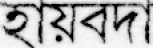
হায়বদা
